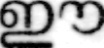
ഈ
